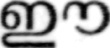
ഈ
